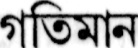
গতিমান
